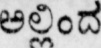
ಅಲ್ಲಿಂದ
